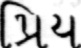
પ્રિય
